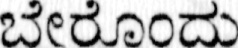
ಬೇರೊಂದು
